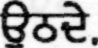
ਉਠਦੇ,
